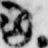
છે.
